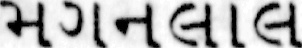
મગનલાલ
